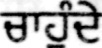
ਚਾਹੁੰਦੇ
